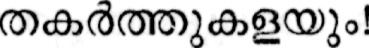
തകര്‍ത്തുകളയും!
